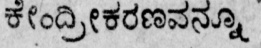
ಕೇಂದ್ರೀಕರಣವನ್ನೂ
